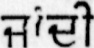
ਜਾਂਦੀ
